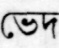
ভেদ
